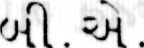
બી.એ.
